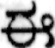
ಈ
